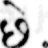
છે.
